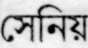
সেনিয়
